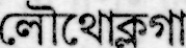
লৌথোক্লগা
